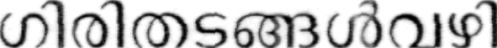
ഗിരിതടങ്ങള്‍വഴി
